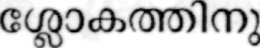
ശ്ലോകത്തിനു
